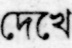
দেখে
